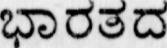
ಭಾರತದ
